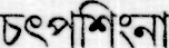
চৎপশিংনা
